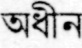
অধীন
